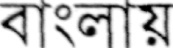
বাংলায়
